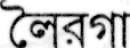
লৈরগা
